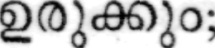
ഉരുക്കും;
